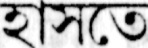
হাসতে
